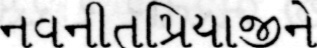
નવનીતપ્રિયાજીને
